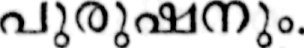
പുരുഷനും.
